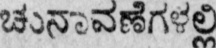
ಚುನಾವಣೆಗಳಲ್ಲಿ
